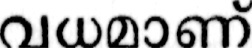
വധമാണ്
